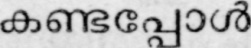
കണ്ടപ്പോള്‍
